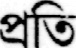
প্রতি
